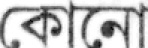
কোনো
